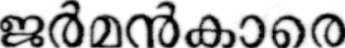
ജര്‍മന്‍കാരെ
